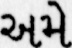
અમે
